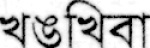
খঙখিবা
